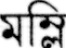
মম্লি
